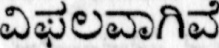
ವಿಫಲವಾಗಿವೆ
